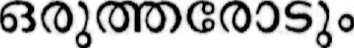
ഒരുത്തരോടും
